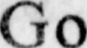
Go
